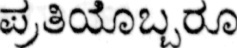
ಪ್ರತಿಯೊಬ್ಬರೂ
